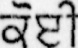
ਕੋਈ
